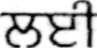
ਲਈ
